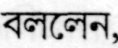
বললেন,
